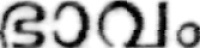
ഭാവം
